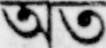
অত
